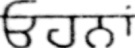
ਓਹਨਾਂ
